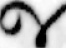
જ
